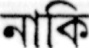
নাকি
